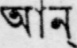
আন্
